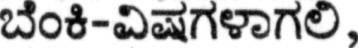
ಬೆಂಕಿ-ವಿಷಗಳಾಗಲಿ,
